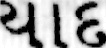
યાદ
